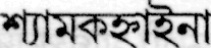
শ্যামকহ্ণাইনা
